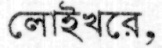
লোইখরে,
